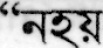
"নহয়
